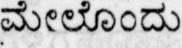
ಮೇಲೊಂದು
